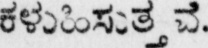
ಕಳುಹಿಸುತ್ತವೆ.
